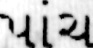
પાંચ
